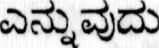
ಎನ್ನುವುದು
